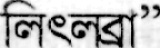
লিৎলব্রা”
